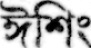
ঈশিং
